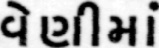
વેણીમાં
